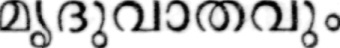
മൃദുവാതവും
